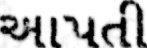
આપતી
